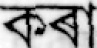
কৰা
